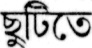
ছুটিতে
